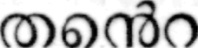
തന്റെ
